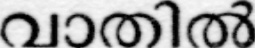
വാതില്‍
